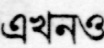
এখনও
